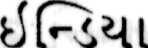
ઇન્ડિયા
